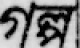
গল্প
